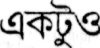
একটুও
